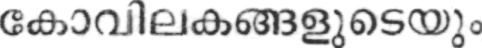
കോവിലകങ്ങളുടെയും
